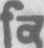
ਕਿ
